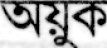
অয়ুক
